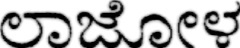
ಲಾಜೋಳ
